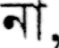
না,
